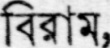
বিরাম,
